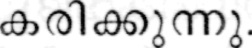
കരിക്കുന്നു.
